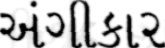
અંગીકાર
